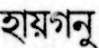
হায়গনু
